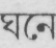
ঘনে
